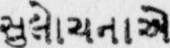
સુલોચનાએ
